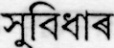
সুবিধাৰ
